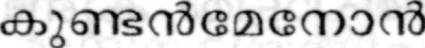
കുണ്ടന്‍മേനോന്‍
